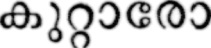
കുറ്റാരോ
